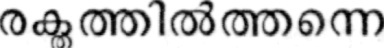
രക്തത്തില്‍ത്തന്നെ
